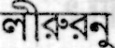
লীরুরনু
